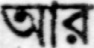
আর
